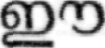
ഈ
